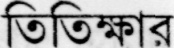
তিতিক্ষার
